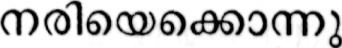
നരിയെക്കൊന്നു
